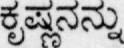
ಕೃಷ್ಣನನ್ನು
